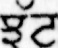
ਝੱਟ
